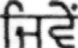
ਜਿਵੇਂ
